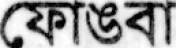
ফোঙবা
